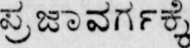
ಪ್ರಜಾವರ್ಗಕ್ಕೆ
